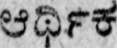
ಆರ್ಥಿಕ
